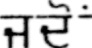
ਜਦੋਂ
